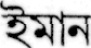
ইমান
